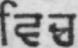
ਵਿਚ
